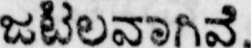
ಜಟಿಲವಾಗಿವೆ.
